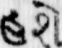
હશે
